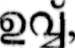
ഉവ്വ്,
